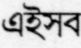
এইসব
